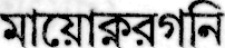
মায়োক্নরগনি
